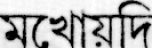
মখোয়দি
